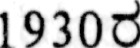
1930ರ
